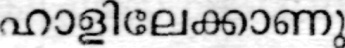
ഹാളിലേക്കാണു
